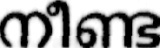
നീണ്ട
